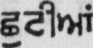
ਛੁਟੀਆਂ
